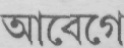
আবেগে
